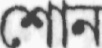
শোন
